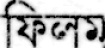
ফিলম
